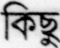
কিছু
